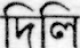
দিলি
